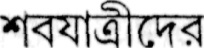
শবযাত্রীদের
